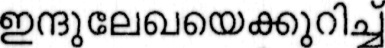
ഇന്ദുലേഖയെക്കുറിച്ച്
